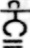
ਨੂੰ
